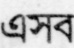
এসব
